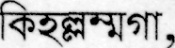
কিহল্লম্মগা,
